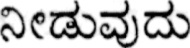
ನೀಡುವುದು
